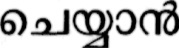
ചെയ്യാന്‍
